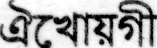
ঐখোয়গী
